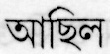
আছিল
